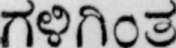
ಗಳಿಗಿಂತ
